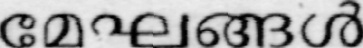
മേഘങ്ങള്‍
